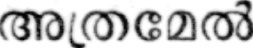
അത്രമേല്‍
